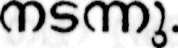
നടന്നു.
